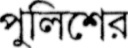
পুলিশের
